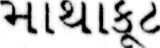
માથાકૂટ
